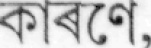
কাৰণে,
